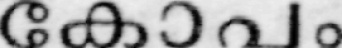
കോപം
